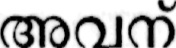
അവന്
